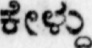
ಕೇಳ್ದು
